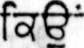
ਕਿਉਂ
